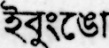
ইবুংঙো
